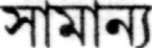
সামান্য
